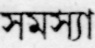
সমস্যা
